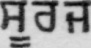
ਸੂਰਜ
